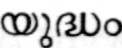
യുദ്ധം
